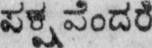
ಪಕ್ಷವೆಂದರೆ
